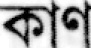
কাণ
